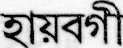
হায়বগী
